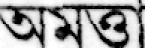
অমত্তা
